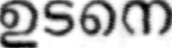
ഉടനെ
